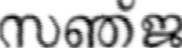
സഞ്ജ
